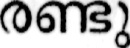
രണ്ടു
